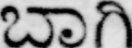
ಬಾಗಿ
